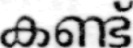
കണ്ട്
